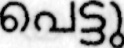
പെട്ടു
